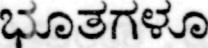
ಭೂತಗಳೂ
